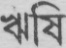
ঋষি
